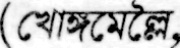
(খোঙ্গমেল্লৈ,
